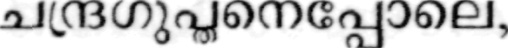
ചന്ദ്രഗുപ്തനെപ്പോലെ,
